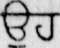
ਉਹ
